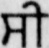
ਸੀ
